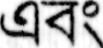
এবং
